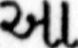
આ
